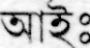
আইঃ
